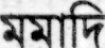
মমাদি
